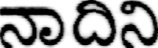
ನಾದಿನಿ
